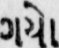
ગયો
